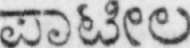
ಪಾಟೀಲ
